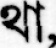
থা,
